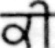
ਕੀ
